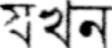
যখন
